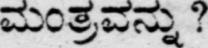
ಮಂತ್ರವನ್ನು?
